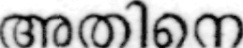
അതിനെ
